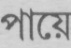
পায়ে
